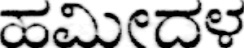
ಹಮೀದಳ
